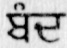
ਬੰਦ
